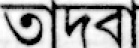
তাদবা
